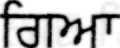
ਗਿਆ
